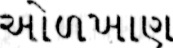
ઓળખાણ
